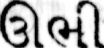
ઊભી
